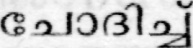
ചോദിച്ച്
